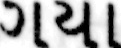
ગયા
